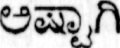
ಅಷ್ಟಾಗಿ
